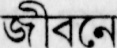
জীবনে
